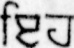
ਇਹ
